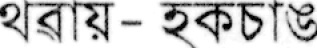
থৱায়-হকচাঙ
